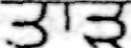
ਤਾੜ
